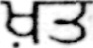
ਖ਼ਤ
